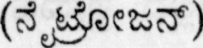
(ನೈಟ್ರೋಜನ್)
